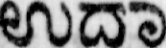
ಉದಾ
